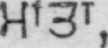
ਮਾਤਾ,
